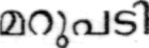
മറുപടി
